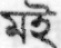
মই
